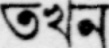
তখন
